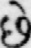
છે
